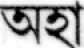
অহা
